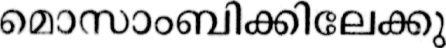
മൊസാംബിക്കിലേക്കു
